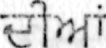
ਦੀਆਂ
